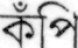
কঁপি
